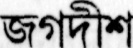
জগদীশ
